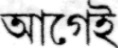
আগেই
